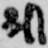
શ્રી
